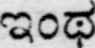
ಇಂಥ
